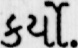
કર્યો.
